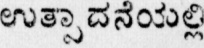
ಉತ್ಪಾದನೆಯಲ್ಲಿ
